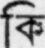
কি
